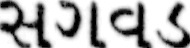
સગવડ
